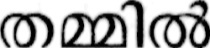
തമ്മില്‍
